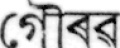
গৌৰৱ
